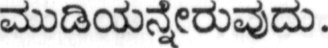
ಮುಡಿಯನ್ನೇರುವುದು.
